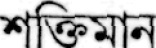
শক্তিমান
